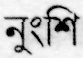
নুংশি
